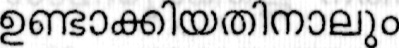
ഉണ്ടാക്കിയതിനാലും
